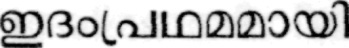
ഇദംപ്രഥമമായി
